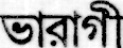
ভারাগী
